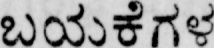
ಬಯಕೆಗಳ
